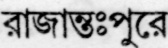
রাজান্তঃপুরে
